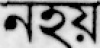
নহয়
